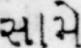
સામે
